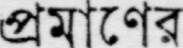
প্রমাণের
